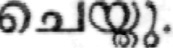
ചെയ്തു.
